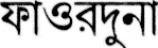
ফাওরদুনা
